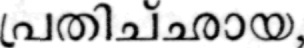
പ്രതിച്ഛായ,
